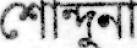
শোন্দুনা
